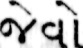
જેવો
